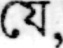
যে,
